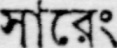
সারেং
